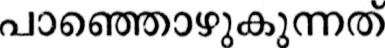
പാഞ്ഞൊഴുകുന്നത്
